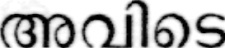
അവിടെ
